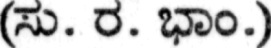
(ಸು.ರ.ಭಾಂ.)
